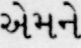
એમને
